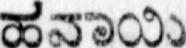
ಹವಾಯಿ
